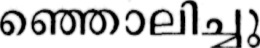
ഞ്ഞൊലിച്ചു
